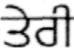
ਤੇਰੀ
